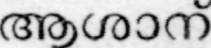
ആശാന്
